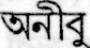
অনীবু
